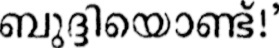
ബുദ്ദിയൊണ്ട്!'
